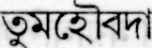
তুমহৌবদা
